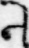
ને
